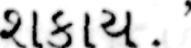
શકાય.'
